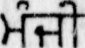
ਮੰਜੀ
